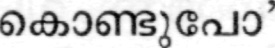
കൊണ്ടുപോ’
